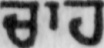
ਚਾਹ
